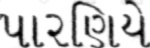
પારણિયે
